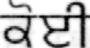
ਕੋਈ
